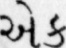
એક
